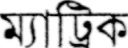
ম্যাট্রিক
